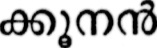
ക്കൂനന്‍
